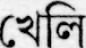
খেলি
